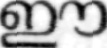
ഈ
